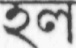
হল
